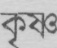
কৃষ্ণ
